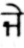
ਜੇ
